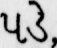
પડે,
